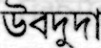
উবদুদা
